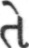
તે
